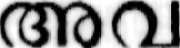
അവ
